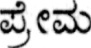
ಪ್ರೇಮ
